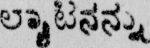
ಲ್ಯಾಟಿನನ್ನು
